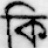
কি
